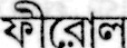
ফীরোল
